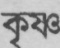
কৃষ্ণ
